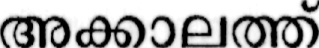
അക്കാലത്ത്
